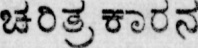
ಚರಿತ್ರಕಾರನ
